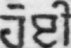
ਹੋਈ
